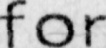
for
